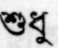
শুধু
